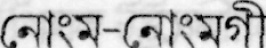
নোংম-নোংমগী
